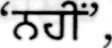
'ਨਹੀਂ',
